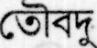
তৌবদু
